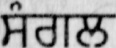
ਸੰਗਲ
